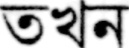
তখন
